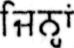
ਜਿਨ੍ਹਾਂ
